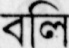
বলি
